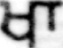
ਖਾ
